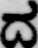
ದ
